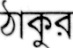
ঠাকুর
